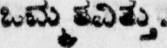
ಒಮ್ಮತವಿತ್ತು.
